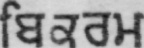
ਬਿਕਰਮ
